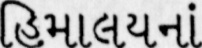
હિમાલયના
